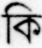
কি
